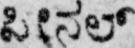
ಪೀನಲ್
